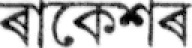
ৰাকেশৰ
